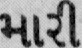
મારી
